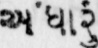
અંધારું
